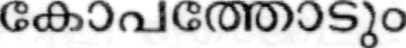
കോപത്തോടും
